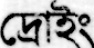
দ্রোইং
